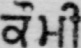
ਕੌਮੀ
